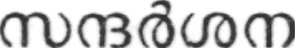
സന്ദര്‍ശന
